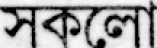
সকলো
